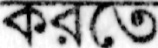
করতে
